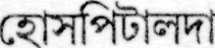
হোসপিটালদা
